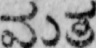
ಮತ
